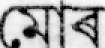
মোৰ
